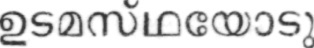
ഉടമസ്ഥയോടു
